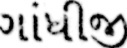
ગાંધીજી
